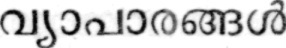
വ്യാപാരങ്ങള്‍
